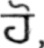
ਹੋ,
